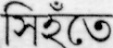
সিহঁতে
